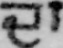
ਦਾ
